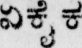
ಏಕೈಕ
